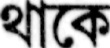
থাকে
